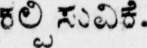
ಕಲ್ಪಿಸುವಿಕೆ.
